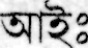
আইঃ
